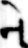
ને
